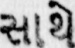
સાથે
